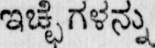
ಇಚ್ಛೆಗಳನ್ನು
